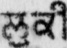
ਲੁਕੀ
